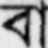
বা
